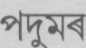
পদুমৰ
